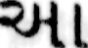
આ
